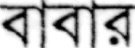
বাবার
